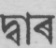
দ্বাৰ
